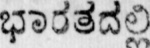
ಭಾರತದಲ್ಲಿ
